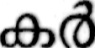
കര്‍
